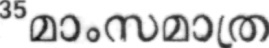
35മാംസമാത്ര
